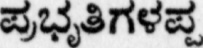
ಪ್ರಭೃತಿಗಳಪ್ಪ
